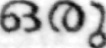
ഒരു
